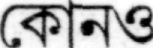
কোনও
